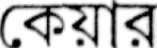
কেয়ার
